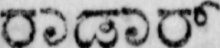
ರಾಡಾರ್
